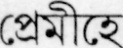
প্রেমীহে
